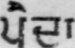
ਪੈਦਾ
